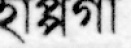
হাপ্পগা
